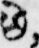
છે,
